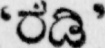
‘ರೆಡಿ’
